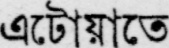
এটোয়াতে
